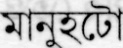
মানুহটো
